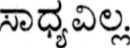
ಸಾಧ್ಯವಿಲ್ಲ.
